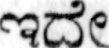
ಇದೇ
